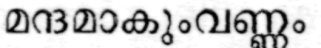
മന്ദമാകുംവണ്ണം
